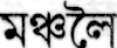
মঞ্চলৈ
